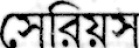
সেরিয়স
